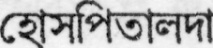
হোসপিতালদা
